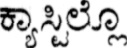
ಕ್ಯಾಸ್ಟಿಲ್ಲೊ
